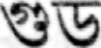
গুড
